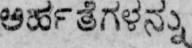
ಅರ್ಹತೆಗಳನ್ನು
